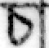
চা
